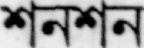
শনশন
